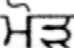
ਮੋੜ
